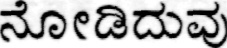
ನೋಡಿದುವು
